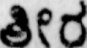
ತೀರ
